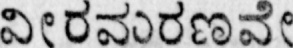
ವೀರಮರಣವೇ
